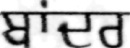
ਬਾਂਦਰ
